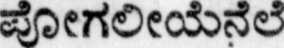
ಪೋಗಲೀಯೆನೆಲೆ
